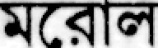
মরোল
